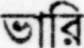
ভারি
